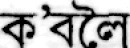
ক'বলৈ
